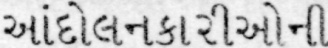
આંદોલનકારીઓની
